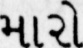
મારો
